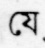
যে
